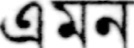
এমন
